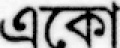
একো
